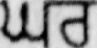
ਘਰ
